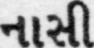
નાસી
